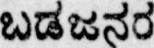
ಬಡಜನರ
